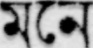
মনে
